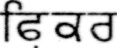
ਫ਼ਿਕਰ
